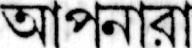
আপনারা
